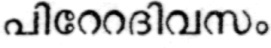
പിറേറദിവസം
